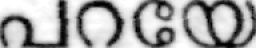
പറയേ
